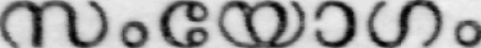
സംയോഗം
